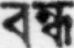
বন্ধ
